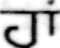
ਹਾਂ
